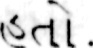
હતો.
